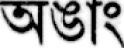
অঙাং
